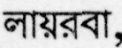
লায়রব,
